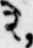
રે,
